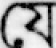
যে
